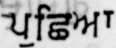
ਪੁਛਿਆ
